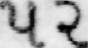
પર
